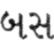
બસ
